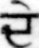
ਦੇ
